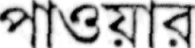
পাওয়ার
